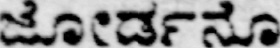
ಜೋರ್ಡನೊ
